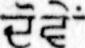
ਦੋਵੇਂ
